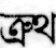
ত্রুথ
